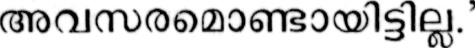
അവസരമൊണ്ടായിട്ടില്ല.’
